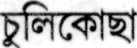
চুলিকোছা
